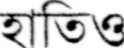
হাতিও
